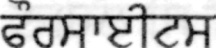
ਫੌਰਸਾਈਟਸ
